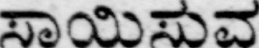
ಸಾಯಿಸುವ
